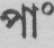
পা
